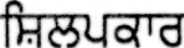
ਸ਼ਿਲਪਕਾਰ
